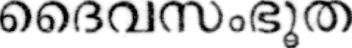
ദൈവസംഭൂത
